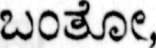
ಬಂತೋ,
